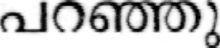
പറഞ്ഞു
